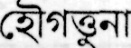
হৌগত্তুনা
